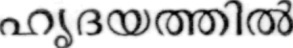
ഹൃദയത്തില്‍
